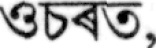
ওচৰত,
